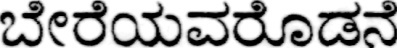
ಬೇರೆಯವರೊಡನೆ
